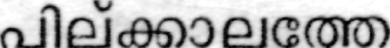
പില്ക്കാലത്തേ
